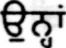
ਉਨ੍ਹਾਂ
